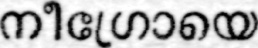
നീഗ്രോയെ
